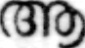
ആ
